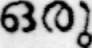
ഒരു
